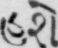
હશે
